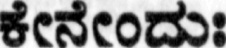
ಕೇನೇಂದುಃ
